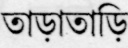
তাড়াতাড়ি
